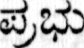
ಪ್ರಭು
